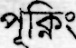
পূক্নিং
